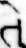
તે
